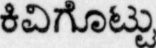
ಕಿವಿಗೊಟ್ಟು
